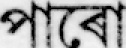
পাৰো
